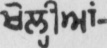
ਖੋਲ੍ਹੀਆਂ-
